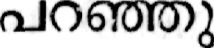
പറഞ്ഞു
